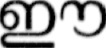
ഈ
